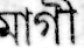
মাগী
